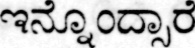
ಇನ್ನೊಂದ್ಸಾರೆ
